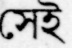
সেই
